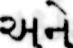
અને
